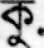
কু.
